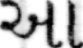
આ
